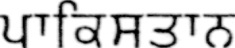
ਪਾਕਿਸਤਾਨ
